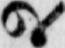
જ”
